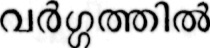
വര്‍ഗ്ഗത്തില്‍
